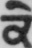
ਕੇ
